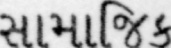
સામાજિક
